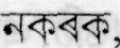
নকৰক,
